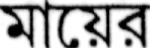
মায়ের
